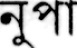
নুপা
